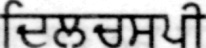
ਦਿਲਚਸਪੀ
